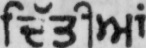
ਦਿੱਤੀਆਂ
